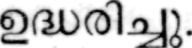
ഉദ്ധരിച്ചു.
